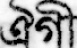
ঐগী
